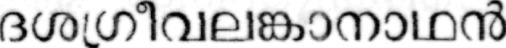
ദശഗ്രീവലങ്കാനാഥന്‍
